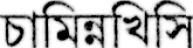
চামিন্নখিসি
